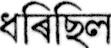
ধৰিছিল
